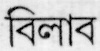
বিলাব
